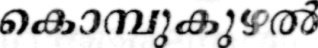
കൊമ്പുകുഴല്‍
